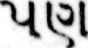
પણ
